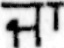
ਜਾ
